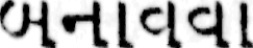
બનાવવા
